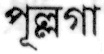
পূল্লগা
